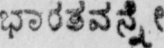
ಭಾರತವನ್ನೇ
